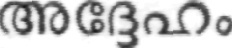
അദ്ദേഹം
